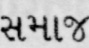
સમાજ
